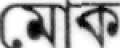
মোক
